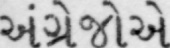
અંગ્રેજોએ
